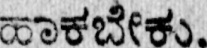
ಹಾಕಬೇಕು.
